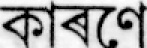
কাৰণে
